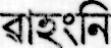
ৱাহংনি
